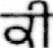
ਕੀ
